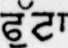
ਫੁੱਟਾ
